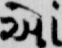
ઓં
